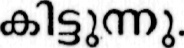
കിട്ടുന്നു.
